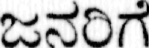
ಜನರಿಗೆ
